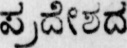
ಪ್ರದೇಶದ
